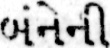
બંનેની
